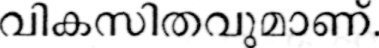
വികസിതവുമാണ്.
